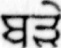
ਬੜੇ
